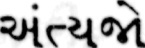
અંત્યજો
